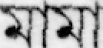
মামা
